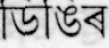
ডিঙিৰ
